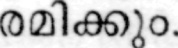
രമിക്കും.
